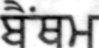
ਬੈਂਥਮ
